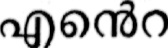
എന്റെ
